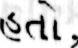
હતો,
